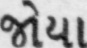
જોયા
